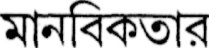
মানবিকতার
